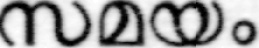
സമയം
